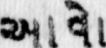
આવો
